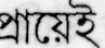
প্রায়েই
